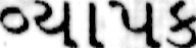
વ્યાપક
